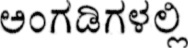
ಅಂಗಡಿಗಳಲ್ಲಿ
